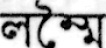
লম্মৈ
